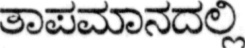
ತಾಪಮಾನದಲ್ಲಿ
